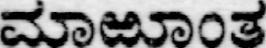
ಮಾಱಾಂತ
